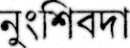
নুংশিবদা
